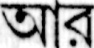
আর
